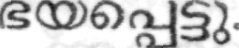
ഭയപ്പെട്ടു.
